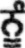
ਨੂੰ
